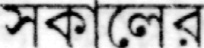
সকালের
